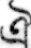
ঐ
